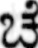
ಚೆ
